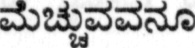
ಮೆಚ್ಚುವವನೂ
